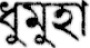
ধুমুহা
